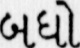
બધો
